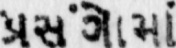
પ્રસંગોમાં
